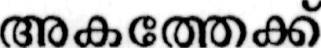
അകത്തേക്ക്
